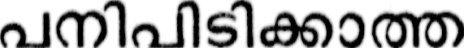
പനിപിടിക്കാത്ത
